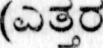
(ಎತ್ತರ
